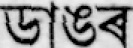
ডাঙৰ
